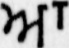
ਆ
